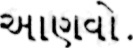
આણવો.
